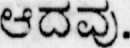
ಆದವು.
